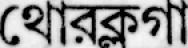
থোরক্লগা
